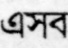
এসব
